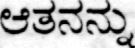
ಆತನನ್ನು
